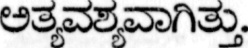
ಅತ್ಯವಶ್ಯವಾಗಿತ್ತು.
